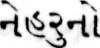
નેહરુનો
